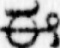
ಈ
